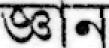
জ্ঞান
